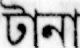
টানা
